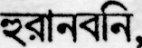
হুরানবনি,
